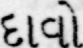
દાવો
